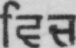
ਵਿਚ
